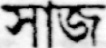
সাজ
